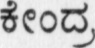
ಕೇಂದ್ರ
